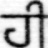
ਹੀ
